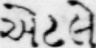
એટલે
